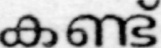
കണ്ട്
